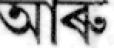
আৰু
